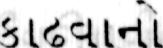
કાઢવાનો
